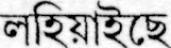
লহিয়াইছে
